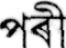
পৰী
